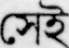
সেই
